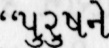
"પુરુષને
